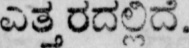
ಎತ್ತರದಲ್ಲಿದೆ.
